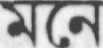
মনে
